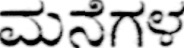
ಮನೆಗಳ
